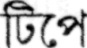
টিপে
